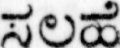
ಸಲಹೆ
